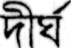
দীর্ঘ
